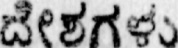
ದೇಶಗಳು
